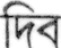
দিব
